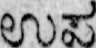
ಉಪ
